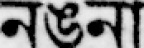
নঙনা
